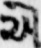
એ
